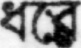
ধরে
